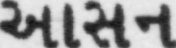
આસન
